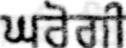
ਘਰੋਗੀ
